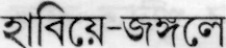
হাবিয়ে-জঙ্গলে
